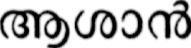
ആശാന്‍
